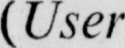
(User
